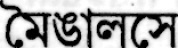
মৈঙালসে
